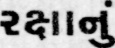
રક્ષાનું
